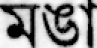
মঙা
